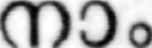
നാം
